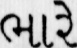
ભારે
